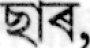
ছাৰ,
